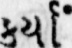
કર્યાં
